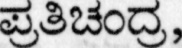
ಪ್ರತಿಚಂದ್ರ,
